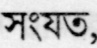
সংযত,
